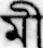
মী
